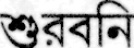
শুরবনি
